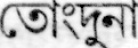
তোংদুনা
